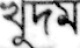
খুদম
